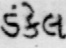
ડંકેલ
